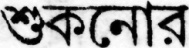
শুকনোর
